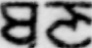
ਬਣ
